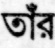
তাঁর
